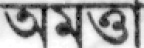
অমত্তা
